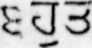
ਬਹੁਤ
